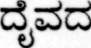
ದೈವದ
